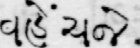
વહેંચજે.
